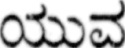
ಯುವ
